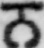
ਨ
